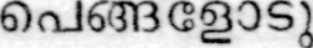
പെങ്ങളോടു
